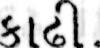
કાઢી.
